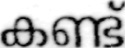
കണ്ട്
